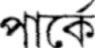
পার্কে
